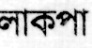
লাকপা
